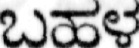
ಬಹಳ
